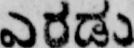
ಎರಡು
